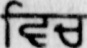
ਵਿਚ
